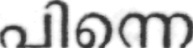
പിന്നെ
